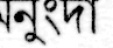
মনুংদা
